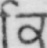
ਕਿ
